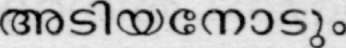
അടിയനോടും
